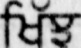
ਖਿੱਝ
